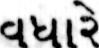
વધારે
